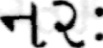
નરઃ
